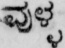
ವುಳ್ಳ
